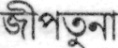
জীপতুনা
